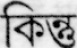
কিন্তু
